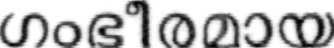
ഗംഭീരമായ
